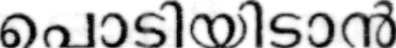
പൊടിയിടാന്‍
